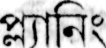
প্ল্যানিং
